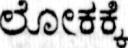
ಲೋಕಕ್ಕೆ
